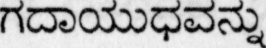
ಗದಾಯುಧವನ್ನು
